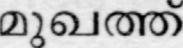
മുഖത്ത്
